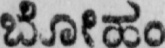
ಬೋಹಂ
